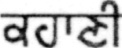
ਕਹਾਣੀ
